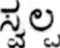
ಸ್ವಲ್ಪ
